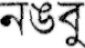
নঙবু
